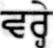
ਵਰ੍ਹੇ
